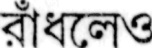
রাঁধলেও
